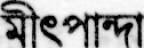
মীৎপান্দা
